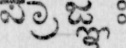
ಪ್ರಾಜ್ಞಃ
